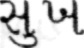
સુખ
